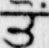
ਤੋਂ
